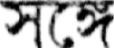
সঙ্গে
